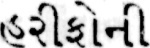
હરીફોની
